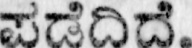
ಪಡೆದಿದೆ.
